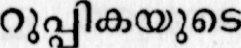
റുപ്പികയുടെ
